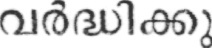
വര്‍ദ്ധിക്കു
